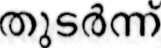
തുടര്‍ന്ന്
